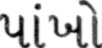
પાંખો
